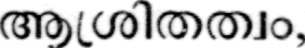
ആശ്രിതത്വം,
